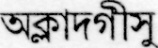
অক্লাদগীসু
